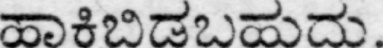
ಹಾಕಿಬಿಡಬಹುದು.
